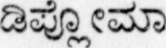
ಡಿಪ್ಲೋಮಾ
